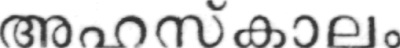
അഹസ്കാലം
